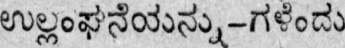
ಉಲ್ಲಂಘನೆಯನ್ನು-ಗಳೆಂದು
